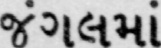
જંગલમાં
